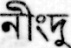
নীংদু
